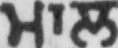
ਮਾਲ
